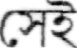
সেই
